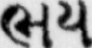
ભય
